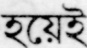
হয়েই
